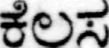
ಕೆಲಸ
